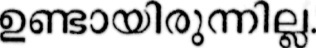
ഉണ്ടായിരുന്നില്ല.
